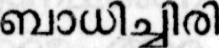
ബാധിച്ചിരി
